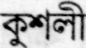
কুশলী
